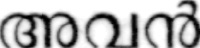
അവന്‍
